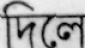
দিলে
